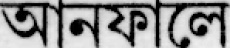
আনফালে
